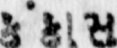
કંકાસ
